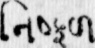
નિષ્ફળ
